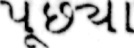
પૂછ્યા
